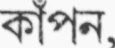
কাঁপন,
